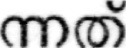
ന്നത്
